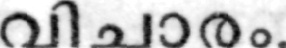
വിചാരം.
